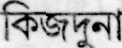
কিজদুনা
